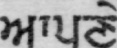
ਆਪਣੇ
